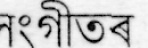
সংগীতৰ
